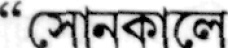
"সোনকালে
